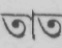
তাত
